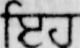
ਇਹ
